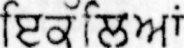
ਇਕੱਲਿਆਂ
